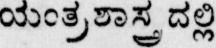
ಯಂತ್ರಶಾಸ್ತ್ರದಲ್ಲಿ
